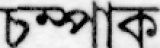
চম্পাক
